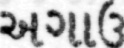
અગાઉ
